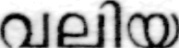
വലിയ
